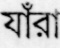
যাঁরা
